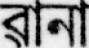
ৱানা
